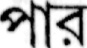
পার
